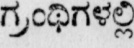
ಗ್ರಂಥಿಗಳಲ್ಲಿ
